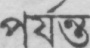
পর্যন্ত
